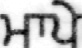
ਮਾਪੇ
